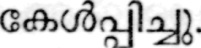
കേള്‍പ്പിച്ചു.
